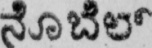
ನೊಬೆಲ್
